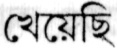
খেয়েছি
